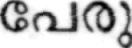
പേരു
